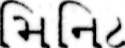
મિનિટ
